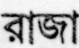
রাজা
